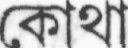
কোথা
